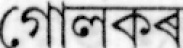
গোলকৰ
